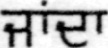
ਜਾਂਦਾ
